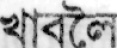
খাবলৈ
